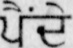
ਪੈਂਦੇ
